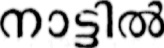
നാട്ടില്‍
